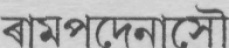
ৰামপদেনাসৌ
